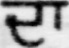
ਦਾ
